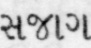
સજાગ
